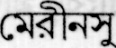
মেরীনসু
